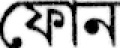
ফোন
